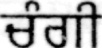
ਚੰਗੀ
